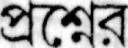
প্রশ্নের
